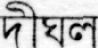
দীঘল
